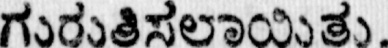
ಗುರುತಿಸಲಾಯಿತು.
